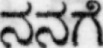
ನನಗೆ
